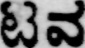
ಟವ
